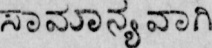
ಸಾಮಾನ್ಯವಾಗಿ
